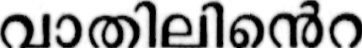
വാതിലിന്റെ
